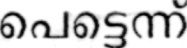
പെട്ടെന്ന്
